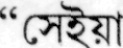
"সেইয়া
